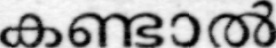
കണ്ടാല്‍
